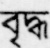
বৃদ্ধ
